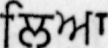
ਲਿਆ
